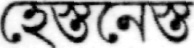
হেস্তনেস্ত
